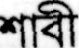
শাবী
